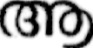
ആ
